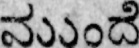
ಮುಂದೆ
